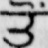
ਤੋਂ
